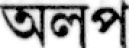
অলপ
